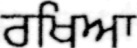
ਰਖਿਆ
